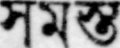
সমস্ত
